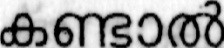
കണ്ടാല്‍
